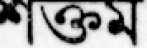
শক্তম
